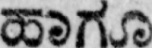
ಹಾಗೂ
